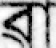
ৱা
